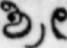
ಶ್ರೀ
